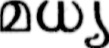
മധ്യ
